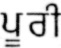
ਪੂਰੀ
